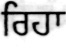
ਰਿਹਾ
